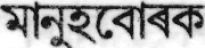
মানুহবোৰক
